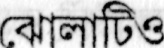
ঝোলাটিও
